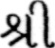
શ્રી
